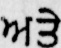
ਅਤੇ
